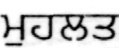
ਮੁਹਲਤ
